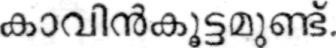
കാവിന്‍കൂട്ടമുണ്ട്.
